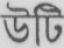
উটি
